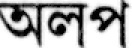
অলপ
